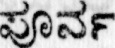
ಪೂರ್ವ
